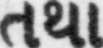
તથા
